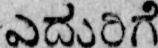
ಎದುರಿಗೆ
